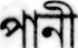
পানী
